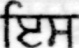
ਇਸ
